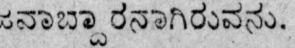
ಜವಬ್ದಾರನಾಗಿರುವನು.
